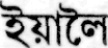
ইয়ালৈ
